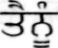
ਤੈਨੂੰ
